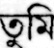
তুমি
